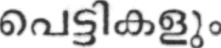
പെട്ടികളും
